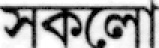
সকলো
